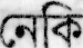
নেকি
